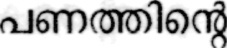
പണത്തിന്റെ
